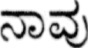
ನಾವು
